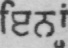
ਇਨ੍ਹਾਂ
